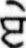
ਏ
